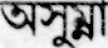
অসুম্না
